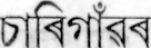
চাৰিগাঁৱৰ
